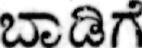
ಬಾಡಿಗೆ
